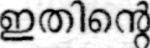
ഇതിന്റെ
